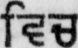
ਵਿਚ
